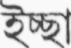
ইচ্ছা
